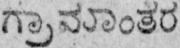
ಗ್ರಾಮಾಂತರ
